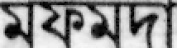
মফমদা
